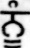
ਨੂੰ
